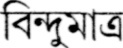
বিন্দুমাত্র
